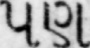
પણ
